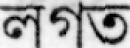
লগত
